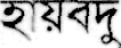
হায়বদু
